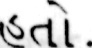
હતો.
